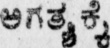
ಅಗತ್ಯಕ್ಕೆ
